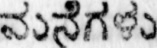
ಮನೆಗಳು
